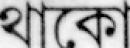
থাকো
